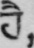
ਹੈ,
